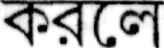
করলে
